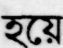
হয়ে
